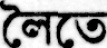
লৈতে
